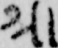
શ્રી
